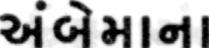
અંબેમાના
